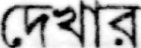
দেখার
